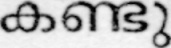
കണ്ടു
